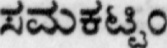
ಸಮಕಟ್ಟಿಂ
